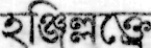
হঞ্জিল্লক্ত্রে
